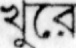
খুরে
